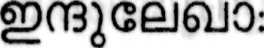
ഇന്ദുലേഖാ:
